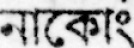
নাকোং
